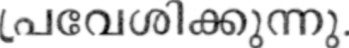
പ്രവേശിക്കുന്നു.
